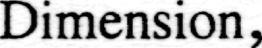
Dimension,
